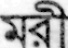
মরী
